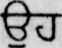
ਉਹ
